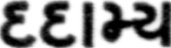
દદામ્ય
